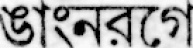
ঙাংনরগে
